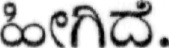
ಹೀಗಿದೆ.
